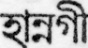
হান্নগী
